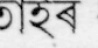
তাইৰ
